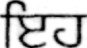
ਇਹ
